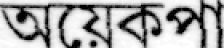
অয়েকপা
